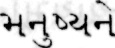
મનુષ્યને
